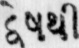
દ્વેષથી
